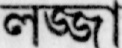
লজ্জা
